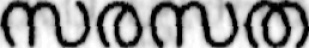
സരസത
